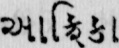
આફ્રિકા
